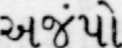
અજંપો
